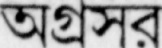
অগ্রসর
